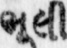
ભૂલી
